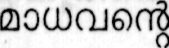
മാധവന്റെ
